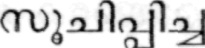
സൂചിപ്പിച്ച
